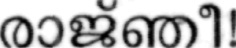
രാജ്ഞീ!
